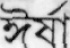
ঈর্ষা
